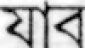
যাব
